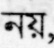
নয়,
